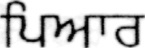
ਪਿਆਰ
